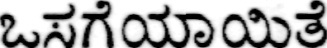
ಒಸಗೆಯಾಯಿತೆ
